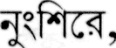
নুংশিরে,
